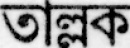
তাল্লক
